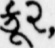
ક્રૂર,
